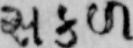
સકળ
